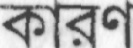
কারণ
